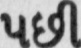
પછી
